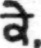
ਕੇ,
